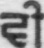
ਵੀ
